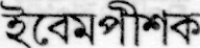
ইবেমপীশক
